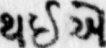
થઈએ
